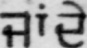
ਜਾਂਦੇ
